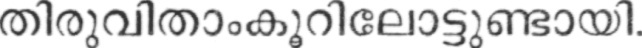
തിരുവിതാംകൂറിലോട്ടുണ്ടായി.
